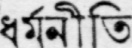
ধর্মনীতি
